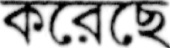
করেছে
